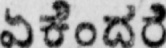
ಏಕೆಂದರೆ
